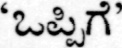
'ಒಪ್ಪಿಗೆ'
